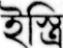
ইস্ত্রি
